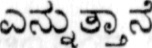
ಎನ್ನುತ್ತಾನೆ
